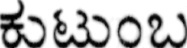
ಕುಟುಂಬ
